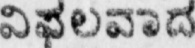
ವಿಫಲವಾದ
